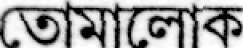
তোমালোক
